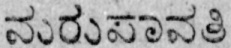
ಮರುಪಾವತಿ
